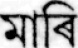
মাৰি
